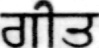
ਗੀਤ
